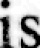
is
